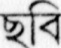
ছবি
